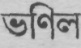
ভণিল
